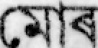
মোৰ
